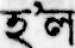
হ'ল
